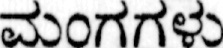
ಮಂಗಗಳು
